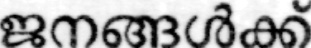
ജനങ്ങള്‍ക്ക്
